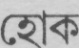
হোক
